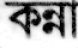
কন্না
